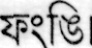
ফংঙি।
